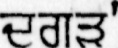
ਦਗੜ'
